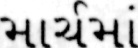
માર્ચમાં
